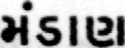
મંડાણ
